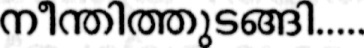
നീന്തിത്തുടങ്ങി.....
